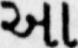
આ
